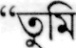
"তুমি
